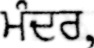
ਮੰਦਰ,
